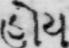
હોય
